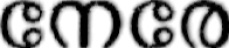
നേരേ
